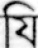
যি
